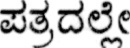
ಪತ್ರದಲ್ಲೇ
